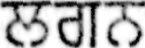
ਲਗਨ
